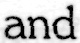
and
